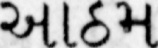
આઠમ
